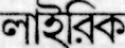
লাইরিক
